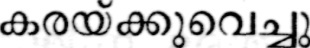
കരയ്ക്കുവെച്ചു
